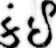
કંઈ
